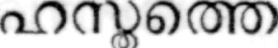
ഹസ്തത്തെ
